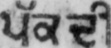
ਪੱਕਦੀ
